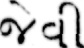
જેવી
